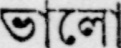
ভালো
